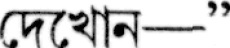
দেখোন-"
